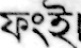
ফংই।
